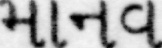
માનવ
